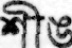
শীঙ
